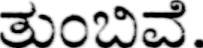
ತುಂಬಿವೆ.
